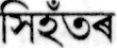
সিহঁতৰ
